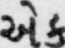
એક
